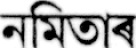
নমিতাৰ
